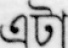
এটা
